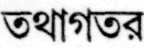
তথাগতর
